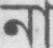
না
